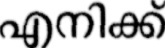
എനിക്ക്
